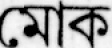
মোক
